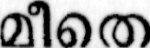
മീതെ
